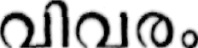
വിവരം
